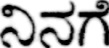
ನಿನಗೆ
